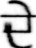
ਦੇ
